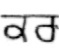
ਕਰ
